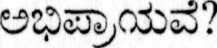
ಅಭಿಪ್ರಾಯವೆ?
